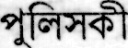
পুলিসকী
